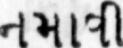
નમાવી
